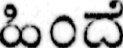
ಹಿಂದೆ
